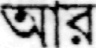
আর
